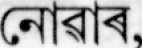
নোৱাৰ,
